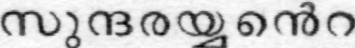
സുന്ദരയ്യന്റെ
